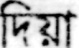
দিয়া
